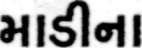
માડીના
